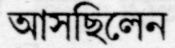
আসছিলেন
